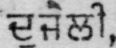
ਦੁਜੈਲੀ,
